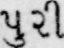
પુરી
